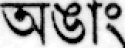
অঙাং
